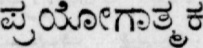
ಪ್ರಯೋಗಾತ್ಮಕ
